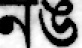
নঙ
